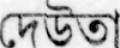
দেউতা
